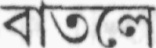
বাতলে
